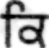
ਕਿ
